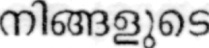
നിങ്ങളുടെ
